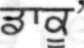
ਡਾਕੂ'
